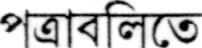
পত্রাবলিতে
